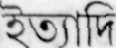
ইত্যাদি
